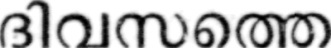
ദിവസത്തെ
